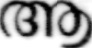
ആ
